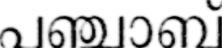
പഞ്ചാബ്
